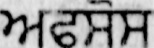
ਅਫਸੋਸ
